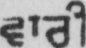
ਵਾਰੀ
